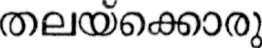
തലയ്ക്കൊരു
